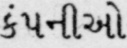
કંપનીઓ
